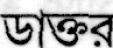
ডাক্তর
